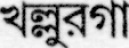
খল্লুরগা
